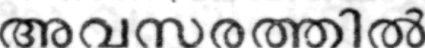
അവസരത്തില്‍
